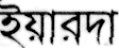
ইয়ারদা
